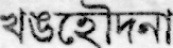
খঙহৌদনা
